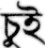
চুই
